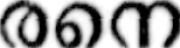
രനെ
